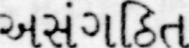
અસંગઠિત
